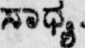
ಸಾಧ್ಯ.
